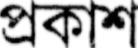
প্রকাশ
